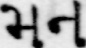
મન
